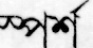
স্পর্শ
